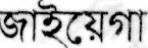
জাইয়েগা
